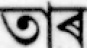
তাৰ
